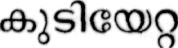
കുടിയേറ്റ
